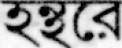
হন্থরে
